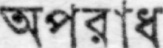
অপরাধ
